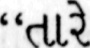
"તારે
